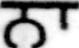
ਨਾ
